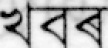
খবৰ
